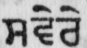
ਸਵੇਰੇ
